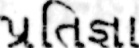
પ્રતિજ્ઞા
